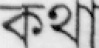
কথা
